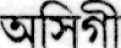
অসিগী
